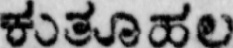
ಕುತೂಹಲ
